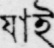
যাই
